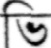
ভি
